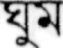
ঘুম
